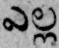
ಎಲ್ಲ
